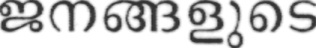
ജനങ്ങളുടെ
